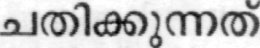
ചതിക്കുന്നത്
